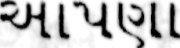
આપણા
